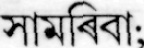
সামৰিবা;
